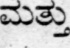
ಮತ್ತು
